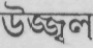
উজ্জ্বল
